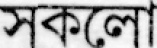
সকলো
